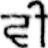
ਵੀ
